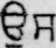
ਉਸ
